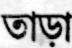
তাড়া
